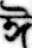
ঈ
